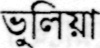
ভুলিয়া
